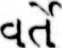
વર્તે
